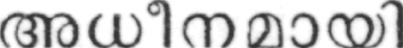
അധീനമായി
